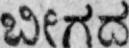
ಬೀಗದ
